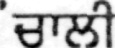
ਚਾਲੀ
